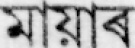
মায়াৰ
